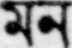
মন
